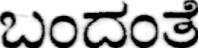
ಬಂದಂತೆ
